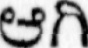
ಆಗಿ
